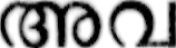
അവ
